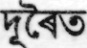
দূৰৈত
